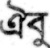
ঐবু
